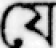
যে
